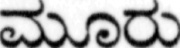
ಮೂರು
